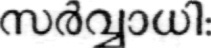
സര്‍വ്വാധി:
